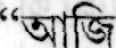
"আজি
